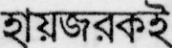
হায়জরকই
